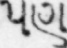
પણ
